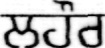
ਲਹੌਰ
